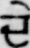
ਦੇ
